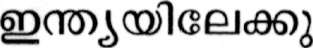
ഇന്ത്യയിലേക്കു
